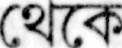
থেকে
